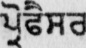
ਪ੍ਰੋਫੈਸਰ
